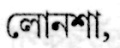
লোনশা,
